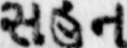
સહન
